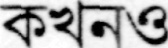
কখনও
